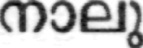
നാലു
